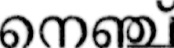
നെഞ്ച്
